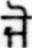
ਜੋ
